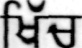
ਖਿੱਚ
